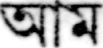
আম
